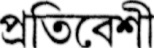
প্রতিবেশী
